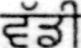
ਵੱਡੀ
